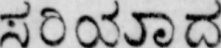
ಸರಿಯಾದ
